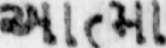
આત્મા
